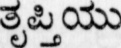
ತೃಪ್ತಿಯು
